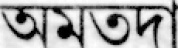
অমতদা
